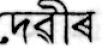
দেৱীৰ
